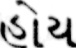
હોય
